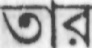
তার
